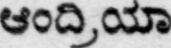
ಆಂದ್ರಿಯಾ
